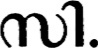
സി.
